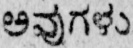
ಅವುಗಳು
